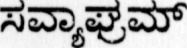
ಸವ್ಯಾಘ್ರಮ್
